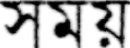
সময়
